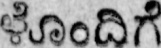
ಳೊಂದಿಗೆ
